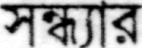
সন্ধ্যার
